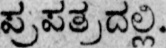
ಪ್ರಪತ್ರದಲ್ಲಿ.
